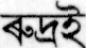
ৰুদ্রই
